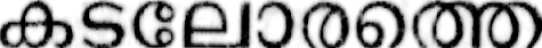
കടലോരത്തെ
